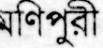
মণিপুরী
